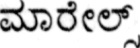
ಮಾರೇಲ್ಸ್
